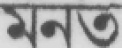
মনত
